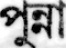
পুন্না
